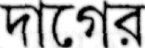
দাগের
